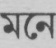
মনে
